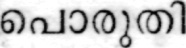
പൊരുതി
